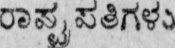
ರಾಷ್ಟ್ರಪತಿಗಳು
